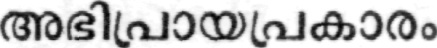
അഭിപ്രായപ്രകാരം
